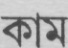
কাম
